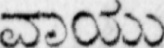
ವಾಯು
